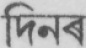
দিনৰ
